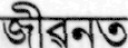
জীৱনত
